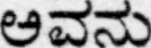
ಅವನು
